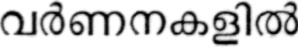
വര്‍ണനകളില്‍
